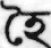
হৈ
